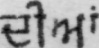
ਦੀਆਂ
